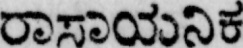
ರಾಸಾಯನಿಕ
